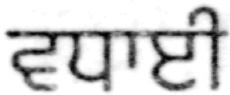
ਵਧਾਈ
